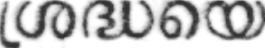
ശ്രദ്ധയെ
